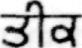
ਤੀਕ
